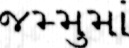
જમ્મુમાં
